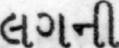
લગની
